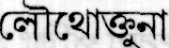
লৌথোক্তুনা
